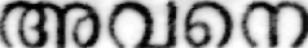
അവനെ
